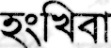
হংখিবা
